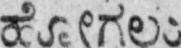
ಹೋಗಲು
